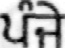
ਪੰਜੇ
